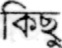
কিছু
